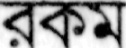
রকম
